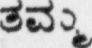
ತಮ್ಮ
